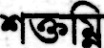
শক্তম্নি
